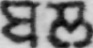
ਬਲ
